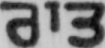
ਰਾਤ
